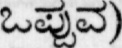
ಒಪ್ಪುವ)
